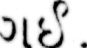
ગઈ.
